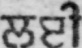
ਲਈ
